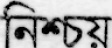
নিশ্চয়
